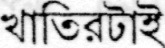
খাতিরটাই
